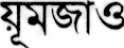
য়ূমজাও
